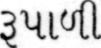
રૂપાળી
